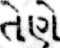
તેણે
